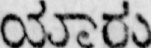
ಯಾರು
